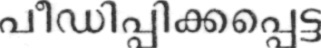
പീഡിപ്പിക്കപ്പെട്ട
